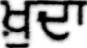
ਖ਼ੁਦਾ
